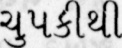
ચુપકીથી
